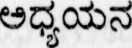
ಅಧ್ಯಯನ
